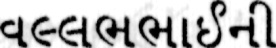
વલ્લભભાઈની
